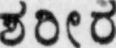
ಶರೀರ
